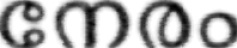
നേരം
